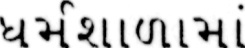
ધર્મશાળામાં
